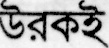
উরকই
